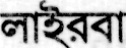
লাইরবা
